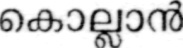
കൊല്ലാന്‍
